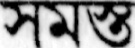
সমস্ত
